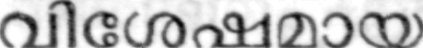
വിശേഷമായ
